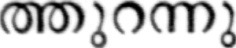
ത്തുറന്നു
